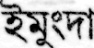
ইমুংদা
